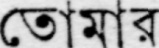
তোমার
